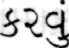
કરવું
